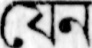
যেন
